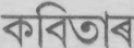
কবিতাৰ
